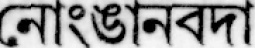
নোংঙানবদা
